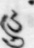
હું
